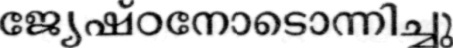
ജ്യേഷ്ഠനോടൊന്നിച്ചു
